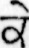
ਕੇ
